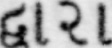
દ્વારા
